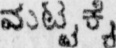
ಮಟ್ಟಕ್ಕೆ
